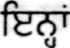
ਇਨ੍ਹਾਂ
